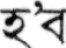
হ'ব
